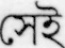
সেই
